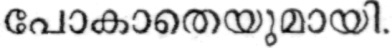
പോകാതെയുമായി.
